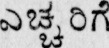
ಎಚ್ಚರಿಗೆ
